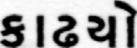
કાઢ્યો
